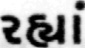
રહ્યાં
